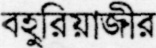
বহুরিয়াজীর
